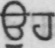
ਉਹ
